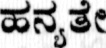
ಹನ್ಯತೇ
